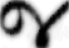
જ
